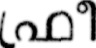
ഫ്രീ
